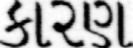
કારણ
